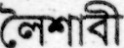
লৈশাবী
